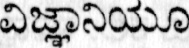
ವಿಜ್ಞಾನಿಯೂ
